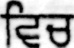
ਵਿਚ
